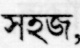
সহজ,
